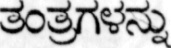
ತಂತ್ರಗಳನ್ನು
